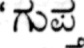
‘ಗುಪ್ತ
